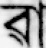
ৱা
